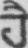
ਹੈ
